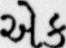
એક
